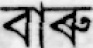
বাৰু
